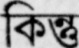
কিন্তু
